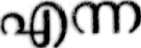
എന്ന
